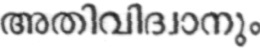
അതിവിദ്വാനും
